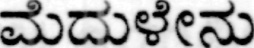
ಮೆದುಳೇನು
